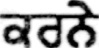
ਕਰਨੇ
